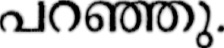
പറഞ്ഞു.
